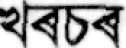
খৰচৰ
